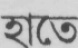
হাতে
